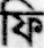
ফি
